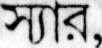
স্যার,
